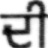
ਦੀ
